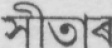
সীতাৰ
